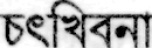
চৎখিবনা
